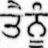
ਤੈਨੂੰ
